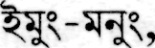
ইমুং-মনুং,
